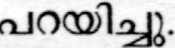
പറയിച്ചു.
